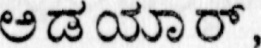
ಅಡಯಾರ್,
